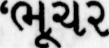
'ભૂચર
